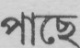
পাছে
